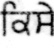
ਕਿਸੇ
